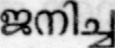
ജനിച്ച
